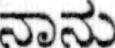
ನಾನು
